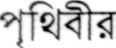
পৃথিবীর
